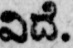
ವಿದೆ.
